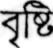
বৃষ্টি
